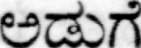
ಅಡುಗೆ
